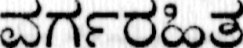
ವರ್ಗರಹಿತ
